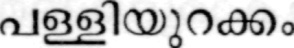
പള്ളിയുറക്കം
